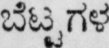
ಬೆಟ್ಟಗಳ
